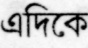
এদিকে
